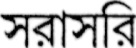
সরাসরি
